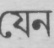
যেন
